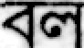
বল
